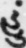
હું
